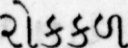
રોકકળ
